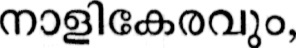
നാളികേരവും,
